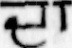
ਦਾ
